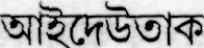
আইদেউতাক
